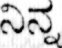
ನಿನ್ನ
